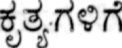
ಕೃತ್ಯಗಳಿಗೆ
